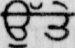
ਉੱਤੇ
